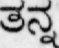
ತನ್ನ
